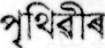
পৃথিৱীৰ
